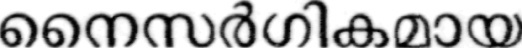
നൈസര്‍ഗികമായ
